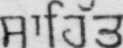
ਸਾਹਿੱਤ
